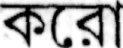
করো
